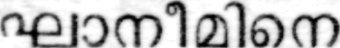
ഘാനീമിനെ
